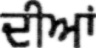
ਦੀਆਂ
